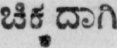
ಚಿಕ್ಕದಾಗಿ
